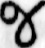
જ
